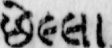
છેલ્લા
